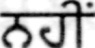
ਨਹੀਂ
